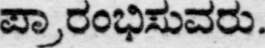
ಪ್ರಾರಂಭಿಸುವರು.
